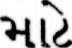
માટે
